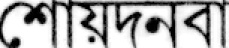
শোয়দনবা
